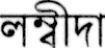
লম্বীদা
